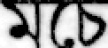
মচে
